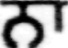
ਨਾ
